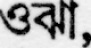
ওঝা,
